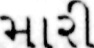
મારી
